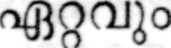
ഏറ്റവും
